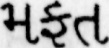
મફત
